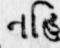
નહિ
